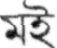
মই
